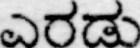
ಎರಡು
